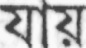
যায়
